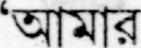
‘আমার
